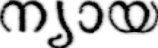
ന്യായ
